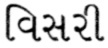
વિસરી
